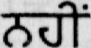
ਨਹੀਂ
